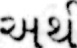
અર્થ
